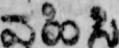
ವಹಿಸಿ
